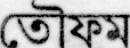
তৌফম
